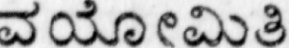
ವಯೋಮಿತಿ
